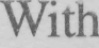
With
